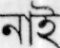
নাই
